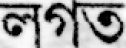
লগত
